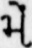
મેં
